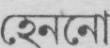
হেননো
